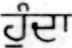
ਹੁੰਦਾ
